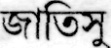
জাতিসু
